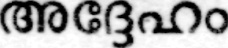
അദ്ദേഹം
